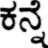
ಕನ್ನೆ
